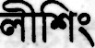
লীশিং
